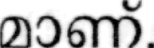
മാണ്.
